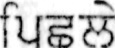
ਪਿਛਲੇ
